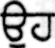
ਉਹ
